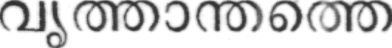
വൃത്താന്തത്തെ
